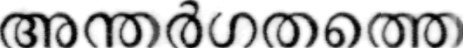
അന്തര്‍ഗതത്തെ
